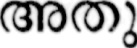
അതു
